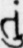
તું
